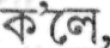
ক'লে,
